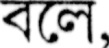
বলে,
